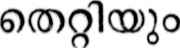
തെറ്റിയും
